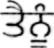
ਤੈਨੂੰ
